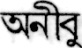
অনীবু
